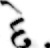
દે.
